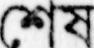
শেষ
